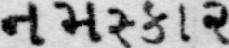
નમસ્કાર
